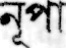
নূপা
